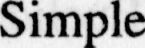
Simple
